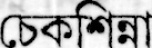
চেকশিন্না
